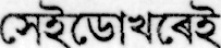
সেইডোখৰেই
